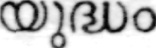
യുദ്ധം
